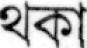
থকা
